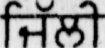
ਜਿੱਲੀ
